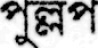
পুল্লপ
